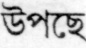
উপছে
